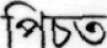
পিচত
